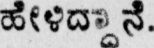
ಹೇಳಿದ್ದಾನೆ.
